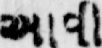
આવી
